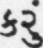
કરું
